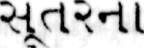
સૂતરના
